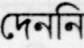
দেননি
